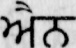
ਐਨ
